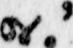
જ.'
